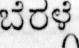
ಬೆರಳ್ಗೆ
